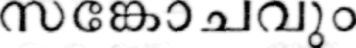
സങ്കോചവും
